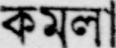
কমলা
